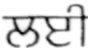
ਲਈ
